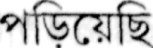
পড়িয়েছি
